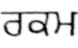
ਰਕਮ
